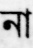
না
